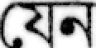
যেন
